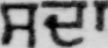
ਸਦਾ
